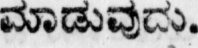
ಮಾಡುವುದು.
